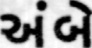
અંબે
